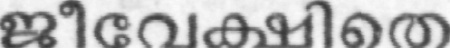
ജീവേക്ഷിതെ
